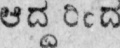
ಆದ್ದರಿಂದ
